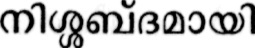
നിശ്ശബ്ദമായി
